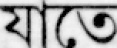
যাতে
